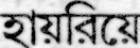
হায়রিয়ে
